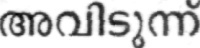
അവിടുന്ന്
